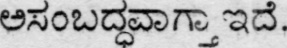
ಅಸಂಬದ್ಧವಾಗ್ತಾಇದೆ.
